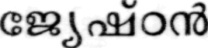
ജ്യേഷ്ഠന്‍
